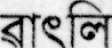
ৱাৎলি
